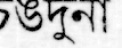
চঙদুনা
